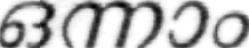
ഒന്നാം
